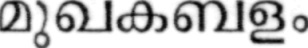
മുഖകബളം
